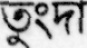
তুংদা
